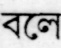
বলে
